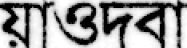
য়াওদবা
